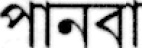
পানবা
